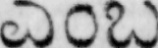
ಎಂಬ
